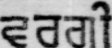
ਵਰਗੀ
